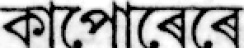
কাপোৰেৰে
